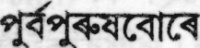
পুৰ্বপুৰুষবোৰে
